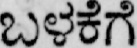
ಬಳಕೆಗೆ
